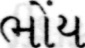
ભોંય
